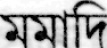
মমাদি
